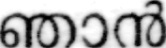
ഞാന്‍
